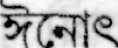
ঈনোৎ
